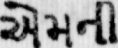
એમની
